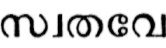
സ്വതവേ
